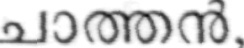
ചാത്തന്‍,
